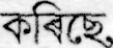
কৰিছে,
